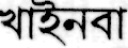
খাইনবগী
